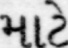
માટે
